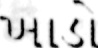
ખાડો
